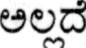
ಅಲ್ಲದೆ
